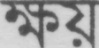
ক্ষয়
